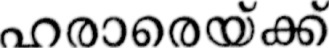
ഹരാരെയ്ക്ക്
